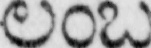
ಲಂಬ
